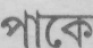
পাকে
